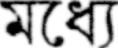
মধ্যে
